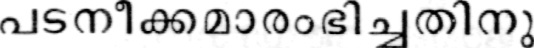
പടനീക്കമാരംഭിച്ചതിനു
